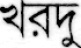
খরদু
